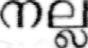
നല്ല
